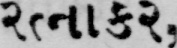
રત્નાકર,
